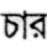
চার
